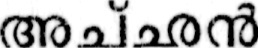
അച്ഛന്‍
